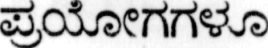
ಪ್ರಯೋಗಗಳೂ
